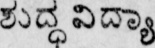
ಶುದ್ಧವಿದ್ಯಾ
